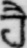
ਹੈ
